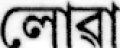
লোৱা
